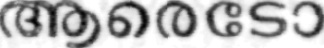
ആരെടോ
